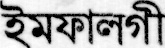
ইমফালগী
